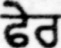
ਫੇਰ
